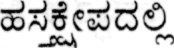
ಹಸ್ತಕ್ಷೇಪದಲ್ಲಿ
